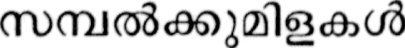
സമ്പല്‍ക്കുമിളകള്‍
